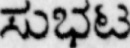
ಸುಭಟ
